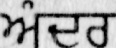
ਅੰਦਰ
